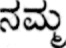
ನಮ್ಮ
